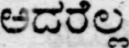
ಅದರೆಲ್ಲ
